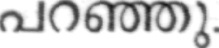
പറഞ്ഞു.
